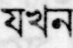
যখন
